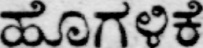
ಹೊಗಳಿಕೆ
